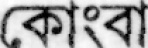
কোংবা
